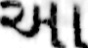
આ
